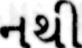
નથી
